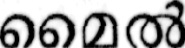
മൈല്‍
